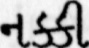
નક્કી
